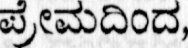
ಪ್ರೇಮದಿಂದ,
